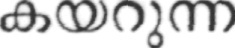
കയറുന്ന
